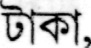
টাকা,
